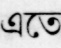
এতে
